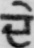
ਦੇ
